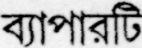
ব্যাপারটি
